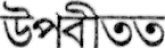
উপবীতত
